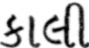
કાલી
